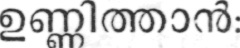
ഉണ്ണിത്താന്‍:
